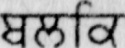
ਬਲਕਿ
